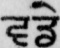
ਵਡੇ
